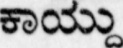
ಕಾಯ್ದು
